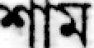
শাম
